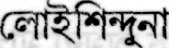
লোইশিন্দুনা
